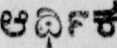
ಆರ್ಥಿಕ
